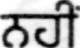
ਨਹੀਂ
